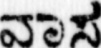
ವಾಸ
